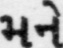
મને
